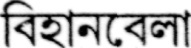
বিহানবেলা
